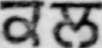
ਕਲ
